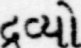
દ્રવ્યો
